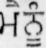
ਮੈਨੂੰ
